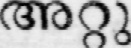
അറ്റു
